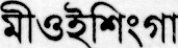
মীওইশিংগা
